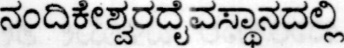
ನಂದಿಕೇಶ್ವರದೈವಸ್ಥಾನದಲ್ಲಿ
